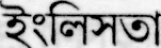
ইংলিসতা
